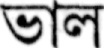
ভাল
